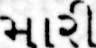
મારી
